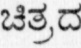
ಚಿತ್ರದ
